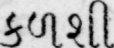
કળશી
